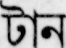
টান
